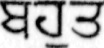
ਬਹੁਤ
